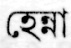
হেন্না
